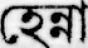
হেন্না
